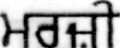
ਮਰਜ਼ੀ
